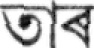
তাৰ
